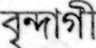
বৃন্দাগী
